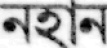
নহান
